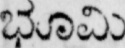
ಭೂಮಿ
